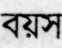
বয়স
